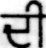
ਦੀ
